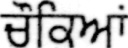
ਚੌਕਿਆਂ
